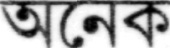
অনেক
